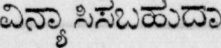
ವಿನ್ಯಾಸಿಸಬಹುದಾ
